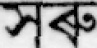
সৰু
